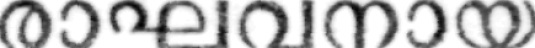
രാഘവനായ
